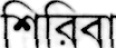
শিরিবা
